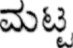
ಮಟ್ಟ
